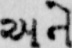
અને
